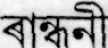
ৰান্ধনী
